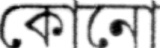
কোনো
